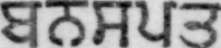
ਬਨਸਪਤ
